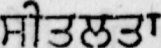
ਸੀਤਲਤਾ
